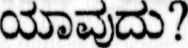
ಯಾವುದು?
